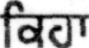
ਕਿਹਾ
